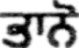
ਭਾਨੋ
